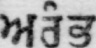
ਅਰੰਭ
